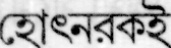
হোৎনরকই
